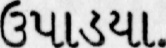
ઉપાડયા.
